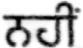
ਨਹੀਂ
